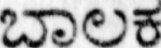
ಬಾಲಕ
